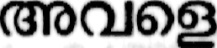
അവളെ
